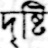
দৃষ্টি
